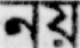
নয়
